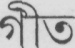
গীত
